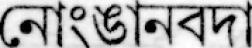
নোংঙানবদা
